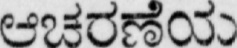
ಆಚರಣೆಯ
